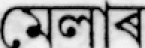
মেলাৰ
